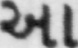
આ
